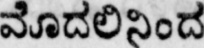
ಮೊದಲಿನಿಂದ
